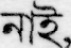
নাই,
